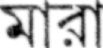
মারা
